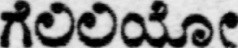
ಗೆಲಿಲಿಯೋ
